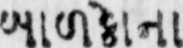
બાળકોના
